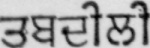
ਤਬਦੀਲੀ
